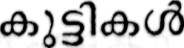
കുട്ടികള്‍
